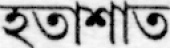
হতাশাত
